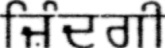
ਜ਼ਿੰਦਗੀ
